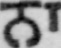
ਨਾ
